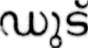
ഡുട്
